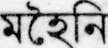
মহৈনি
